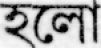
হলো
